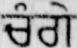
ਚੰਗੇ
